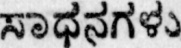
ಸಾಧನಗಳು
